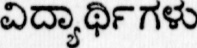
ವಿದ್ಯಾರ್ಥಿಗಳು
